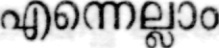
എന്നെല്ലാം
